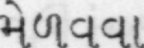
મેળવવા
